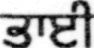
ਭਾਈ
